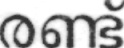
രണ്ട്
